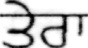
ਤੇਰਾ
